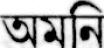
অমনি
